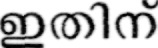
ഇതിന്
